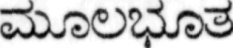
ಮೂಲಭೂತ
